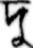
দু
